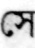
সে
